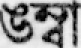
ঙম্বা
